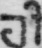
ਹੀ
